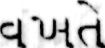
વખતે
